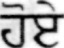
ਹੋਏ
